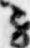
કે
